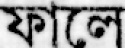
ফালে
